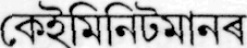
কেইমিনিটমানৰ
